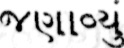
જણાવ્યું
